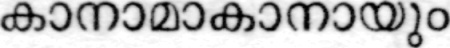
കാനാമാകാനായും
